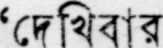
‘দেখিবার
